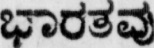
ಭಾರತವು
